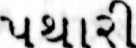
પથારી
